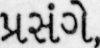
પ્રસંગે,
